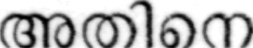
അതിനെ
